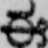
ಈ
